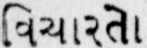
વિચારતો
